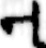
ન
